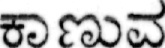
ಕಾಣುವ
